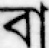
বা
